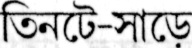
তিনটে-সাড়ে
